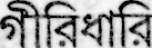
গীরিধারি
